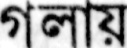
গলায়
